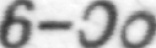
6-ാം
